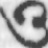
ও
